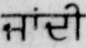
ਜਾਂਦੀ
